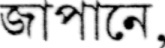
জাপানে,
